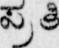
ಪ್ರತಿ
